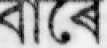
বাৰে
